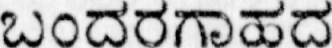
ಬಂದರಗಾಹದ
